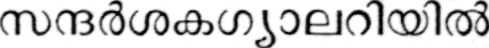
സന്ദര്‍ശകഗ്യാലറിയില്‍
